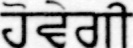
ਹੋਵੇਗੀ
